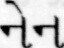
નેન
